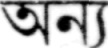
অন্য
